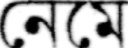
নেমে
